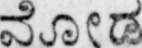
ಮೋಡ
